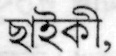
ছাইকী,
